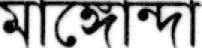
মাঙ্গোন্দা
